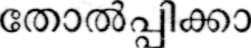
തോല്‍പ്പിക്കാ
